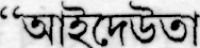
"আইদেউতা
